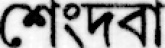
শেংদবা
